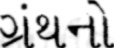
ગ્રંથનો
